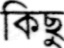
কিছু
